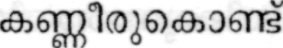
കണ്ണീരുകൊണ്ട്
